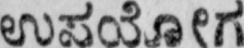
ಉಪಯೋಗ
